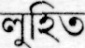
লুহিত
